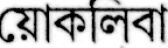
য়োকলিবা
